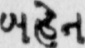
બહેન
